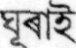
ঘূৰাই
